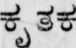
ಕೃತಕ
